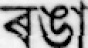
ৰঙা
